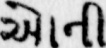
ઓની
